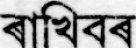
ৰাখিবৰ
